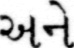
અને
